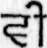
ਵੀ
